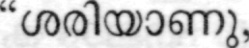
“ശരിയാണു,
